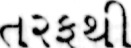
તરફથી
